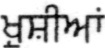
ਖ਼ੁਸ਼ੀਆਂ
